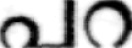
പറ
